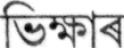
ভিক্ষাৰ
